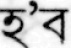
হ'ব
